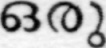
ഒരു
